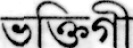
ভক্তিগী
